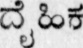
ದೈಹಿಕ
